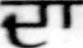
ਦਾ
